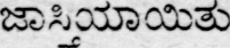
ಜಾಸ್ತಿಯಾಯಿತು
